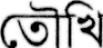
তৌখি
